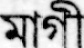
মাগী
